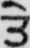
ਤੇ
